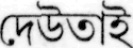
দেউতাই
